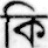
কি
